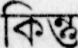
কিন্তু
